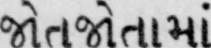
જોતજોતામાં
